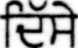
ਦਿੱਸੇ
